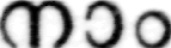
നാം
